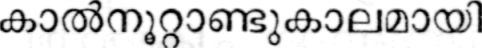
കാല്‍നൂറ്റാണ്ടുകാലമായി
